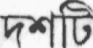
দশটি
